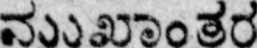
ಮುಖಾಂತರ
